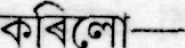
কৰিলো-
